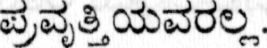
ಪ್ರವೃತ್ತಿಯವರಲ್ಲ.
